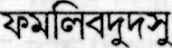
ফমলিবদুদসু
